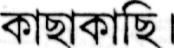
কাছাকাছি।
